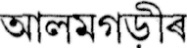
আলমগড়ীৰ
